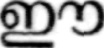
ഈ
